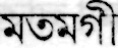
মতমগী
